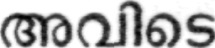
അവിടെ
